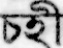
চহী
